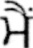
ਮੈਂ
